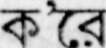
ক'রে
